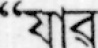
"যাৱ
